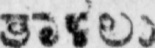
ತಾಳಲು
